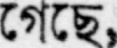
গেছে,
